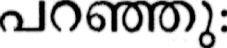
പറഞ്ഞു:
